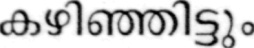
കഴിഞ്ഞിട്ടും
